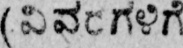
(ವಿವರಗಳಿಗೆ
